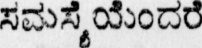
ಸಮಸ್ಯೆಯೆಂದರೆ
